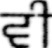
ਵੀ
